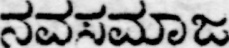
ನವಸಮಾಜ
